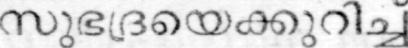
സുഭദ്രയെക്കുറിച്ച്
